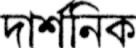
দার্শনিক
